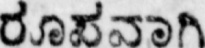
ರೂಪವಾಗಿ
